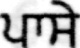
ਪਾਸੇ
